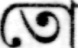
তো
